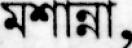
মশান্না,
